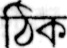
ঠিক
